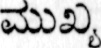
ಮುಖ್ಯ
